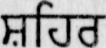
ਸ਼ਹਿਰ
